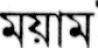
ময়াম
